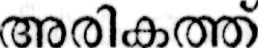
അരികത്ത്
